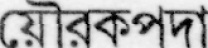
য়ৌরকপদা
